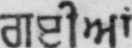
ਗਈਆਂ
